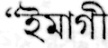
“ইমাগী
